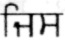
ਜਿਸ
